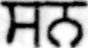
ਸਨ
